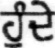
ਹੁੰਦੇ
